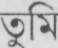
তুমি
